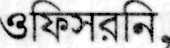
ওফিসরনি,
